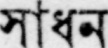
সাধন
